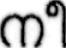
നീ
